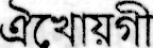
ঐখোয়গী
